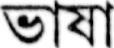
ভাষা
